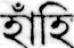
হাঁহি
